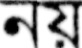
নয়
